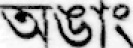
অঙাং
